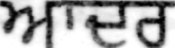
ਆਦਰ
